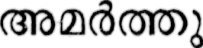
അമര്‍ത്തു
